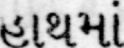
હાથમાં
